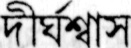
দীর্ঘশ্বাস
